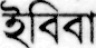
ইবিবা
